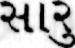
સારુ
